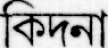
কিদনা
